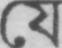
যে
